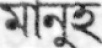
মানুহ
